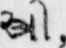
સ્ત્રી,
